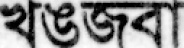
খঙজবা
